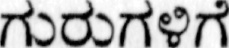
ಗುರುಗಳಿಗೆ
